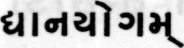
ધાનયોગમ્
